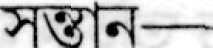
সন্তান-
